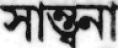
সান্ত্বনা
